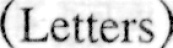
(Letters)
